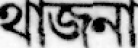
থাজনা
